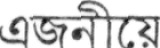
এজনীয়ে
